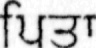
ਪਿਤਾ
